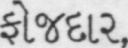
ફોજદાર,
